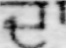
ਦਾ
